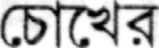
চোখের
